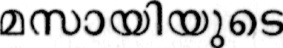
മസായിയുടെ
